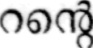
റന്റെ
